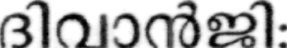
ദിവാന്‍ജി:
